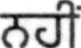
ਨਹੀਂ
